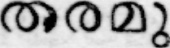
തരമു
